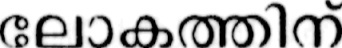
ലോകത്തിന്
